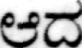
ಆದ
